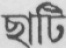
ছাটি
